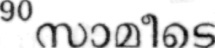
90സാമീടെ
